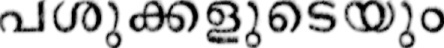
പശുക്കളുടെയും
